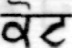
ਕੋਟ
